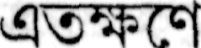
এতক্ষণে
